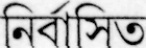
নির্বাসিত
